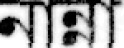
নান্না
